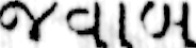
જવાબ
